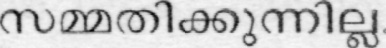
സമ്മതിക്കുന്നില്ല.
